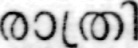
രാത്രി
